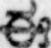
ಈ
